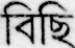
বিছি
